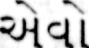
એવો
